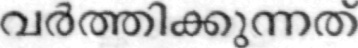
വര്‍ത്തിക്കുന്നത്
